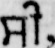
ਸੀ,
